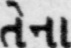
તેના
